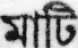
মাটি
